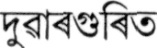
দুৱাৰগুৰিত
